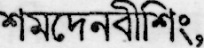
শমদেনবীশিং,
